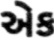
એક
